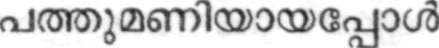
പത്തുമണിയായപ്പോള്‍
